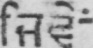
ਜਿਵੇਂ
